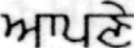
ਆਪਣੇ
